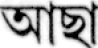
আছা
